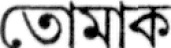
তোমাক
